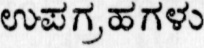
ಉಪಗ್ರಹಗಳು
